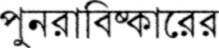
পুনরাবিষ্কারের
